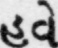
હવે
